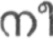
നീ
